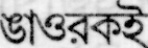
ঙাওরকই
